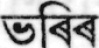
ভৰিৰ
